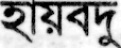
হায়বদু
